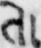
તો
